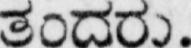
ತಂದರು.
